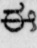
ಈ
